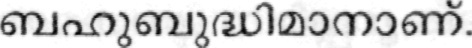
ബഹുബുദ്ധിമാനാണ്.
